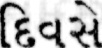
દિવસે
